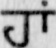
ਹਾਂ
